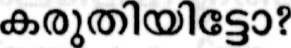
കരുതിയിട്ടോ?
